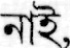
নাই,
